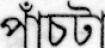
পাঁচটা
